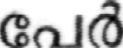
പേര്‍
